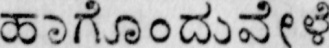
ಹಾಗೊಂದುವೇಳೆ
